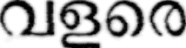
വളരെ
